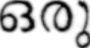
ഒരു
